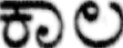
ಕಾಲ
